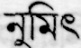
নুমিৎ
